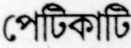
পেটিকাটি
